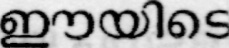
ഈയിടെ
